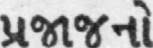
પ્રજાજનો
